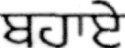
ਬਹਾਏ
